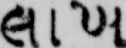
લાખ
